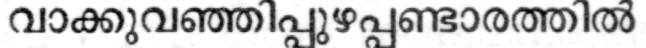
വാക്കുവഞ്ഞിപ്പുഴപ്പണ്ടാരത്തില്‍
